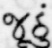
જૂઠું
